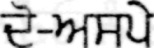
ਦੋ-ਅਸਪੇ
